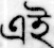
এই
